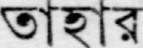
তাহার
